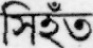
সিহঁত
